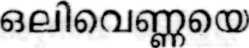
ഒലിവെണ്ണയെ
